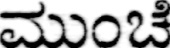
ಮುಂಚೆ
